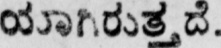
ಯಾಗಿರುತ್ತದೆ.
